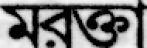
মরক্তা
